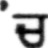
'ਚ
